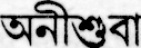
অনীশুবা
